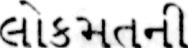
લોકમતની
